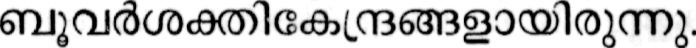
ബൂവര്‍ശക്തികേന്ദ്രങ്ങളായിരുന്നു.
